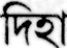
দিহা
